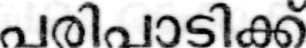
പരിപാടിക്ക്
